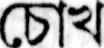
চোখ
